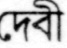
দেবী
